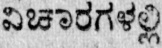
ವಿಚಾರಗಳಲ್ಲಿ
